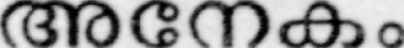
അനേകം
